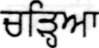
ਚੜ੍ਹਿਆ
